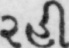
રહી
